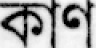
কাণ
